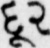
દૂર
